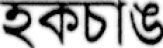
হকচাঙ
